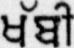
ਖੱਬੀ
